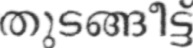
തുടങ്ങീട്ട്
